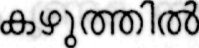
കഴുത്തില്‍
